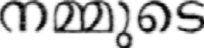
നമ്മുടെ
